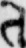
તે
